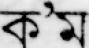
ক'ম
